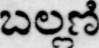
ಬಲ್ಲಣಿ
